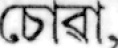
চোৱা,
